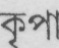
কৃপা
